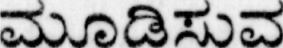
ಮೂಡಿಸುವ
